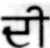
ਦੀ
